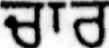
ਚਾਰ
